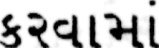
કરવામાં
